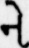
ને
